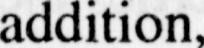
addition,
